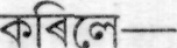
কৰিলে-
